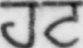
ਹਟ
